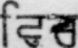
ਵਿਚ
